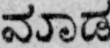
ಮಾಡ
